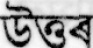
উত্তৰ
